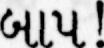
બાપ!
